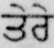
ਤੇਰੇ
